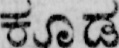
ಕೂಡ
